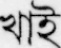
খাই
